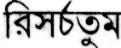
রিসর্চতুম
